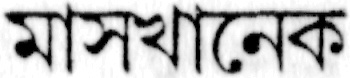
মাসখানেক
